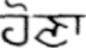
ਹੋਣਾ
